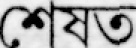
শেষত
